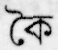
কৈ
